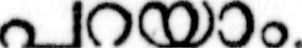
പറയാം.
